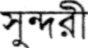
সুন্দরী
